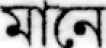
মানে
